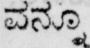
ವನ್ನೂ
